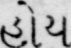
હોય
